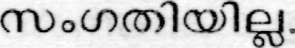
സംഗതിയില്ല.
